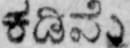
ಕಡಿಮೆ
